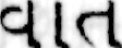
વાત
